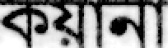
কয়ানা
